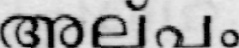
അല്പം
